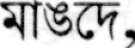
মাঙদে,
